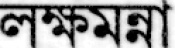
লক্ষমন্না
